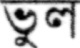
ভুল
